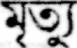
মৃত্যু
